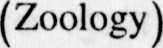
(Zoology)
